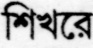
শিখরে
